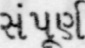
સંપૂર્ણ
